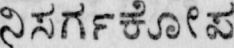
ನಿಸರ್ಗಕೋಪ
